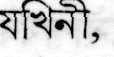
যখিনী,
